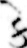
કે
